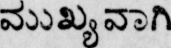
ಮುಖ್ಯವಾಗಿ
